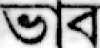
ভাব
